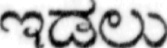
ಇಡಲು
